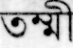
তম্মী
